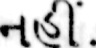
નહીં.
